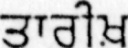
ਤਾਰੀਖ਼
